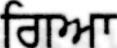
ਗਿਆ
